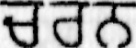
ਚਰਨ
